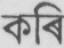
কৰি
